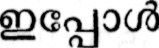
ഇപ്പോള്‍
